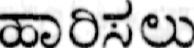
ಹಾರಿಸಲು
